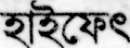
হাইফেৎ
